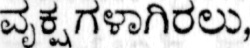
ವೃಕ್ಷಗಳಾಗಿರಲು,
